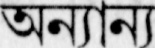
অন্যান্য
